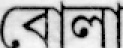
বোলা
